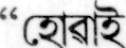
"হোৱাই
